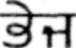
ਭੇਜ
